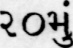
20મું
